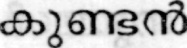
കുണ്ടന്‍
